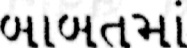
બાબતમાં
